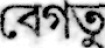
বেগতু
